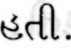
હતી.
